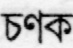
চণক
